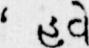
'હવે
